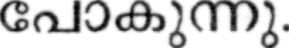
പോകുന്നു.
